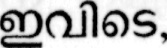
ഇവിടെ,
